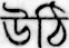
উঠি
